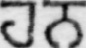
ਹਨ
